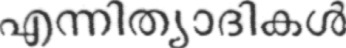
എന്നിത്യാദികള്‍
